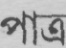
পাত্র
